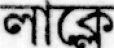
লাক্লে
